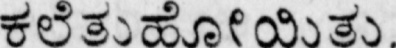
ಕಲೆತುಹೋಯಿತು.
